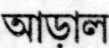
আড়াল
